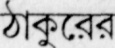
ঠাকুরের
